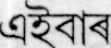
এইবাৰ
